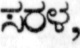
ಸರಳ,
